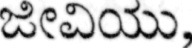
ಜೀವಿಯು,
